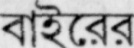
বাইরের
